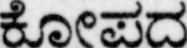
ಕೋಪದ
